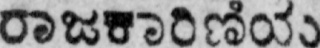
ರಾಜಕಾರಿಣಿಯ
